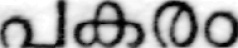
പകരം
